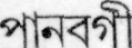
পানবগী
